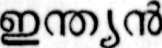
ഇന്ത്യന്‍
